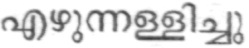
എഴുന്നള്ളിച്ചു
